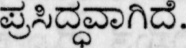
ಪ್ರಸಿದ್ಧವಾಗಿದೆ.
